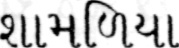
શામળિયા
